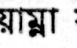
য়াম্না
